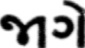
જાગે
